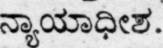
ನ್ಯಾಯಾಧೀಶ.
